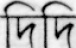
দিদি
